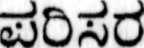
ಪರಿಸರ
